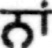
ਨਾਂ
